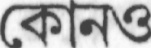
কোনও
